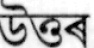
উত্তৰ
